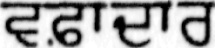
ਵਫ਼ਾਦਾਰ
